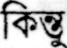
কিন্তু
